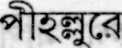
পীহল্লুরে
